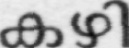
കഴി
